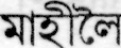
মাহীলৈ
